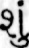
શું
